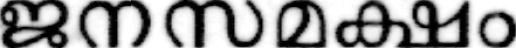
ജനസമക്ഷം
